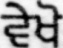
ਵੇਖੋ
